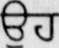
ਉਹ
